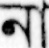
না
